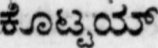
ಕೊಟ್ಟಯ್
